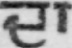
ਦਾ
